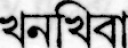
খনখিবা
